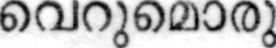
വെറുമൊരു
